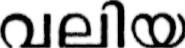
വലിയ
